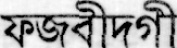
ফজবীদগী
